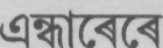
এন্ধাৰেৰে
